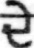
ਦੇ
